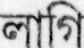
লাগি
